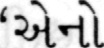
'એનો
